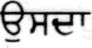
ਉਸਦਾ
